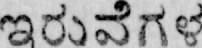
ಇರುವೆಗಳ
